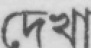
দেখা
